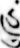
હું
